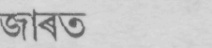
জাৰত
